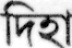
দিহা
